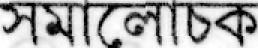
সমালোচক
